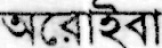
অরোইবা
